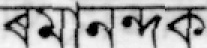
ৰমানন্দক
